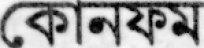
কোনফম
